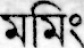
মমিং
